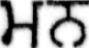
ਮਨ
